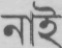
নাই
